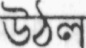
উঠল
